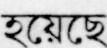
হয়েছে
